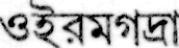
ওইরমগদ্রা
